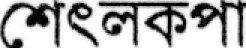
শেৎলকপা
